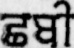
ਛਬੀ
